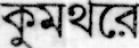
কুমথখ্রে
